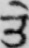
ਤੇ
